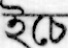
ইচে
